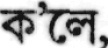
ক'লে,
